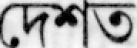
দেশত
